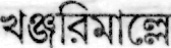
খঞ্জরিমাল্লে
